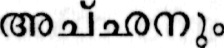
അച്ഛനും
